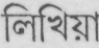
লিখিয়া
